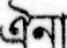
ঐনা
